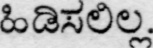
ಹಿಡಿಸಲಿಲ್ಲ.
